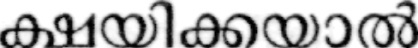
ക്ഷയിക്കയാല്‍
